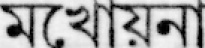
মখোয়না
